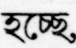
হচ্ছে,
